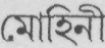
মোহিনী
